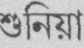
শুনিয়া
